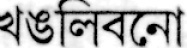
খঙলিবনো
